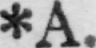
*A.
